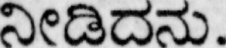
ನೀಡಿದನು.
